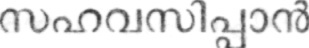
സഹവസിപ്പാന്‍
